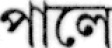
পালে
